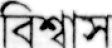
বিশ্বাস
